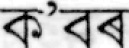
ক'বৰ
